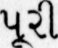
પૂરી
